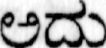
ಅದು
